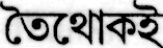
তৈথোকই
